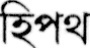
হিপথ
